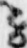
કે
